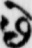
છે
